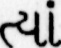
ત્યાં
